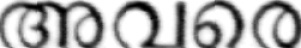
അവരെ
